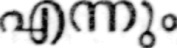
എന്നും
